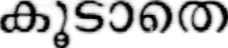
കൂടാതെ
